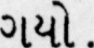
ગયો.
